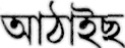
আঠাইছ
